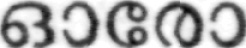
ഓരോ
